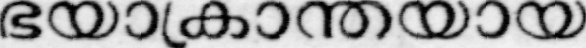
ഭയാക്രാന്തയായ
